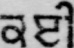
ਕਈ
